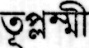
তূপ্লম্মী
